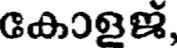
കോളജ്,
